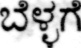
ಬೆಳ್ಳಗೆ
